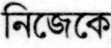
নিজেকে
